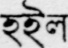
হইল
